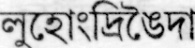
লুহোংদ্রিঙৈদা
